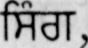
ਸਿੰਗ,
